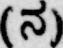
(ನ)
